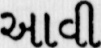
આવી
